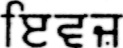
ਇਵਜ਼
